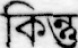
কিন্তু
